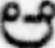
ಆ
